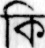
কি
